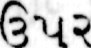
ઉપર
